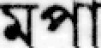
মপা
